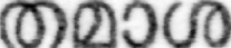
തമാശ
